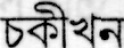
চকীখন
